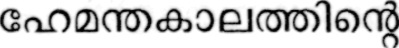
ഹേമന്തകാലത്തിന്റെ
